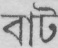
বাট
